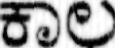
ಕಾಲ
